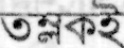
তম্লকই
